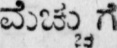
ಮೆಚ್ಚುಗೆ
